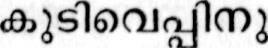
കുടിവെപ്പിനു
